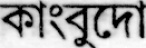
কাংবুদো
